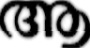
ആ
